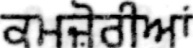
ਕਮਜ਼ੋਰੀਆਂ
